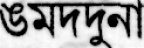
ঙমদদুনা
